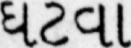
ઘટવા
